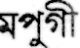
মপুগী
